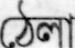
ঠেলা
